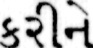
કરીને
